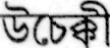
উচেক্কী
